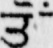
ਤੋਂ
